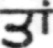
ਤਾਂ
